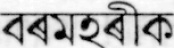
বৰমহৰীক
